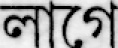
লাগে
